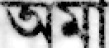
অমা
